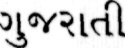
ગુજરાતી
